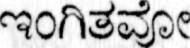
ಇಂಗಿತವೋ
